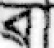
ৱা
